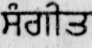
ਸੰਗੀਤ
